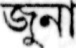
জুনা
